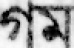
গম
